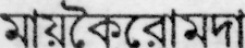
মায়কৈরোমদা
